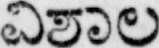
ವಿಶಾಲ
